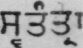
ਸ੍ਵਤੰਤ੍ਰਾ
